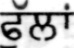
ਫੁੱਲਾਂ
